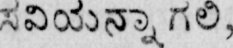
ಸವಿಯನ್ನಾಗಲಿ,
